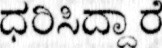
ಧರಿಸಿದ್ದಾರೆ
